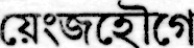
য়েংজহৌগে
